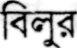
বিলুর
